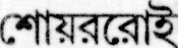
শোয়ররোই
